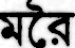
মরৈ
